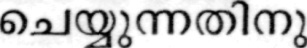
ചെയ്യുന്നതിനു
